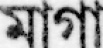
মাগা
